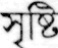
সৃষ্টি
